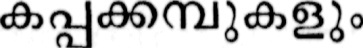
കപ്പക്കമ്പുകളും
